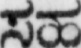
ಸಹ
